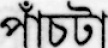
পাঁচটা
